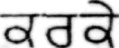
ਕਰਕੇ
